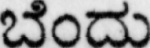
ಬೆಂದು
